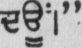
ਦਊਂ''
